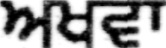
ਅਖਵਾ
